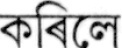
কৰিলে
